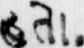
હતો.
